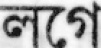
লগে
